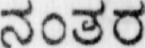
ನಂತರ
